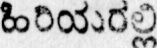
ಹಿರಿಯರಲ್ಲಿ
